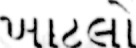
ખાટલો
